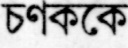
চণককে
